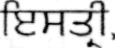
ਇਸਤ੍ਰੀ,
